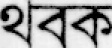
থবক
